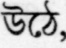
উঠে,
